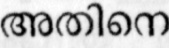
അതിനെ
